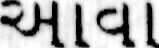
આવા
